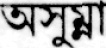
অসুম্না
